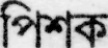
পিশক
